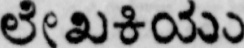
ಲೇಖಕಿಯು
